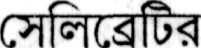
সেলিব্রেটির
